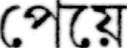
পেয়ে
